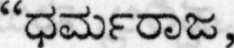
“ಧರ್ಮರಾಜ,
